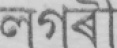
লগৰী
